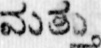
ಮತ್ತು
